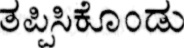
ತಪ್ಪಿಸಿಕೊಂಡು
